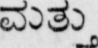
ಮತ್ತು
